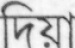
দিয়া
